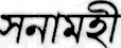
সনামহী
